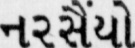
નરસૈંયો
